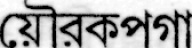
য়ৌরকপগা
